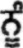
ਨੂੰ
